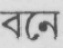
বনে
